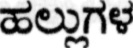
ಹಲ್ಲುಗಳ
